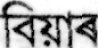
বিয়াৰ
